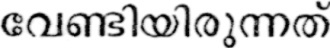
വേണ്ടിയിരുന്നത്
